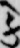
કે
